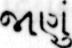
જાણું
